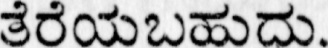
ತೆರೆಯಬಹುದು.
